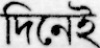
দিনেই
